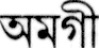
অমগী
